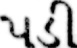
પડી
